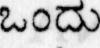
ಒಂದು
